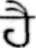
ਹੈ
